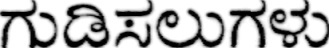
ಗುಡಿಸಲುಗಳು
